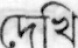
দেখি
